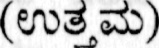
(ಉತ್ತಮ)
